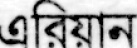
এরিয়ান
